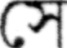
সে
